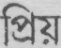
প্ৰিয়
